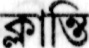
ক্লান্তি
